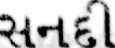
સનદી
